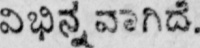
ವಿಭಿನ್ನವಾಗಿದೆ.
